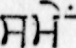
ਸਮੇਂ
